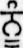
ਨੂੰ
